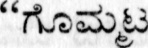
"ಗೊಮ್ಮಟ
